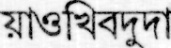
য়াওখিবদুদা
